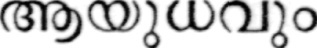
ആയുധവും
